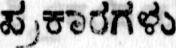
ಪ್ರಕಾರಗಳು
